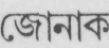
জোনাক
